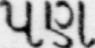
પણ
